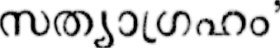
സത്യാഗ്രഹം’
